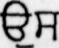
ਉਸ
